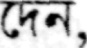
দেন,
